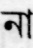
না
